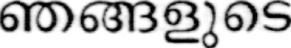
ഞങ്ങളുടെ
